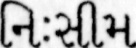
નિઃસીમ
